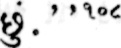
છું."૧૦૮
